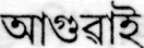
আগুৱাই
